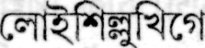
লোইশিল্লুখিগে
